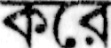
করে
